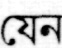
যেন
